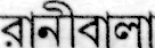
রানীবালা
